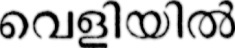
വെളിയില്‍
